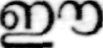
ഈ
